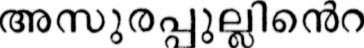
അസുരപ്പുല്ലിന്റെ
